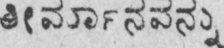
ತೀರ್ಮಾನವನ್ನು
